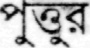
পুত্তুর
